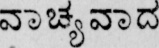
ವಾಚ್ಯವಾದ
